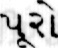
પરો
